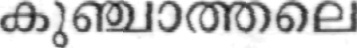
കുഞ്ചാത്തലെ
